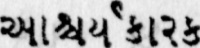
આશ્ચર્યકારક
